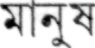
মানুষ
